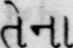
તેના
